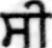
ਸੀ
